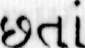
છતાં
